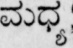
ಮಧ್ಯ
